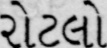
રોટલો
